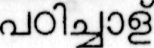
പഠിച്ചാള്
